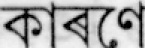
কাৰণে
